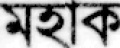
মহাক
